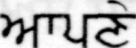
ਆਪਣੇ
